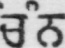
ਚਿੰਨ
